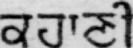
ਕਹਾਣੀ
